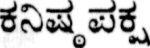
ಕನಿಷ್ಠಪಕ್ಷ
